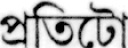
প্রতিটো
